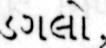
ડગલો,
